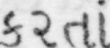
કરતાં
